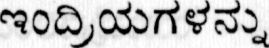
ಇಂದ್ರಿಯಗಳನ್ನು
